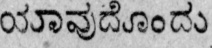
ಯಾವುದೊಂದು
